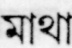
মাথা
